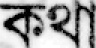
কথা
